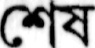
শেষ
